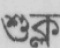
শুক্ল
